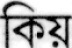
কিয়
